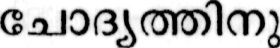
ചോദ്യത്തിനു
